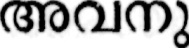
അവനു
